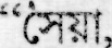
"সেয়া,
